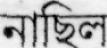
নাছিল
